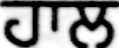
ਹਾਲ
